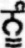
ਨੂੰ
